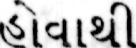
હોવાથી
